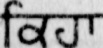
ਕਿਹਾ
